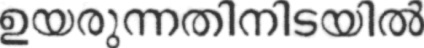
ഉയരുന്നതിനിടയില്‍
